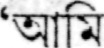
‘আমি
